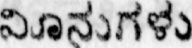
ಮೀನುಗಳು
